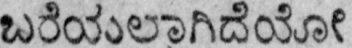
ಬರೆಯಲಾಗಿದೆಯೋ
